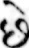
છે
